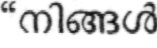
“നിങ്ങള്‍
